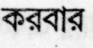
করবার
